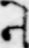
ને
